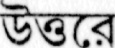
উত্তরে
